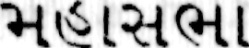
મહાસભા
